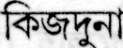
কিজদুনা
